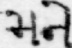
મને
